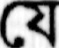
যে
